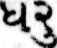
ધરુ
